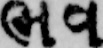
ભવ
